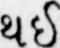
થઈ
